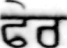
ਫੇਰ
